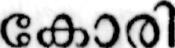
കോരി
